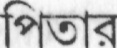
পিতার
